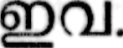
ഇവ.
